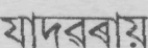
যাদৱৰায়
